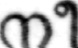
നീ
